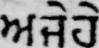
ਅਜੇਹੇ
